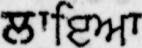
ਲਾਇਆ
